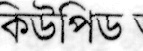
কিউপিড
